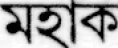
মহাক
